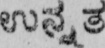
ಉನ್ನತ
